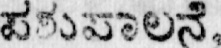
ಪಶುಪಾಲನೆ,
